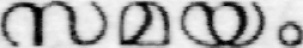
സമയം
